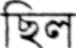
ছিল
